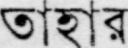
তাহার
